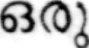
ഒരു
